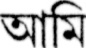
আমি
